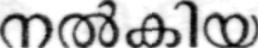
നല്‍കിയ
